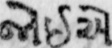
જોઈએ
